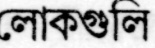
লোকগুলি
